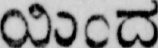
ಯಿಂದ
